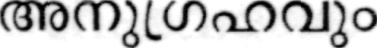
അനുഗ്രഹവും
